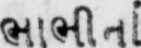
ભાભીનાં
